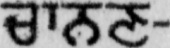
ਚਾਨਣ-
